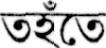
তহঁতে
